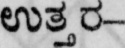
ಉತ್ತರ-
